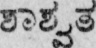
ಶಾಶ್ವತ
